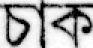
চাক
